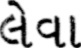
લેવા
